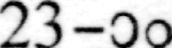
23-ാം
